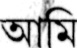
আমি
